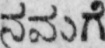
ನಮಗೆ
